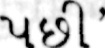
પછી'
